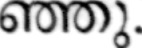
ഞ്ഞു.
